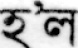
হ'ল
